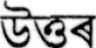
উত্তৰ
